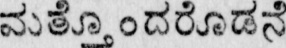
ಮತ್ತೊಂದರೊಡನೆ
